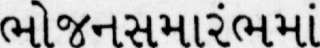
ભોજનસમારંભમાં
